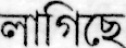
লাগিছে
